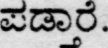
ಪಡ್ತಾರೆ.
